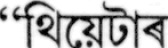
"থিয়েটাৰ
